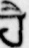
ਹੈ
